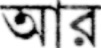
আর
